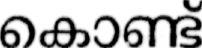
കൊണ്ട്
